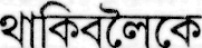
থাকিবলৈকে
